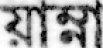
য়াম্না
